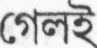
গেলই
